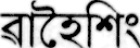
ৱাহৈশিং
